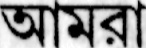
আমরা
